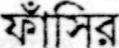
ফাঁসির
